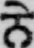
ਨੇ
